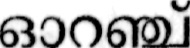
ഓറഞ്ച്
